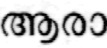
ആരാ
